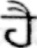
ਹੈ
